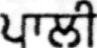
ਪਾਲੀ
